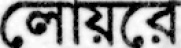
লোয়রে
